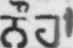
ਨੌਹਾਂ
